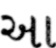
આ
